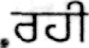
ਰਹੀ
